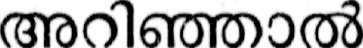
അറിഞ്ഞാല്‍
